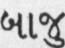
બાજુ
